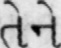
તેને
